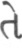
તે
